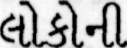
લોકોની
